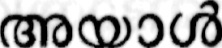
അയാള്‍
